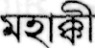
মহাক্কী
